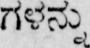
ಗಳನ್ನು
